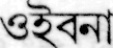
ওইবনা
